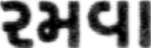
રમવા
